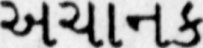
અચાનક
